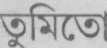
তুমিতো
